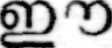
ഈ
